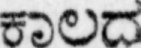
ಕಾಲದ
